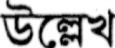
উল্লেখ
